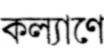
কল্যাণে
